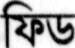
ফিড
